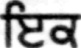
ਇਕ
